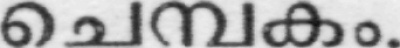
ചെമ്പകം.
